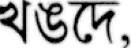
খঙদে,
